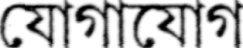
যোগাযোগ
